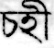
চহী
